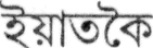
ইয়াতকৈ
